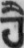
ਹੈ
